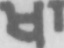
ਖਾ
